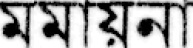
মমায়না
